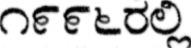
೧೯೯೬ರಲ್ಲಿ
